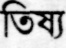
তিষ্য
